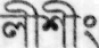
লীশীং
